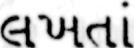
લખતાં
